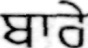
ਬਾਰੇ
